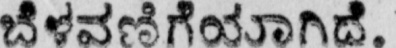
ಬೆಳವಣಿಗೆಯಾಗಿದೆ.
